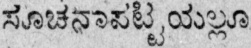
ಸೂಚನಾಪಟ್ಟಿಯಲ್ಲೂ
